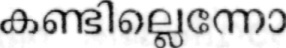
കണ്ടില്ലെന്നോ
